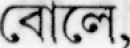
বোলে,
